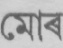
মোৰ
